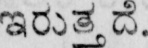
ಇರುತ್ತದೆ.
